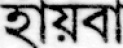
হায়বা
